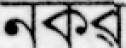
নকৱ
